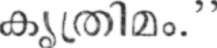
കൃത്രിമം."
